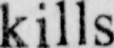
kills
